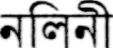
নলিনী
